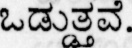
ಒಡ್ಡುತ್ತವೆ.
